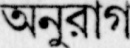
অনুরাগ
